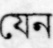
যেন
